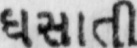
ઘસાતી
